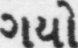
ગયો
